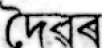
দৈৱৰ
